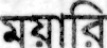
ময়ারি
